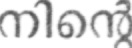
നിന്റെ
